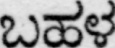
ಬಹಳ
